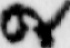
જ
